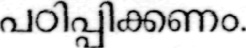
പഠിപ്പിക്കണം.
